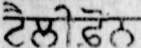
ਟੈਲੀਫ਼ੋਨ
